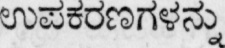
ಉಪಕರಣಗಳನ್ನು
